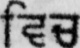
ਵਿਚ
